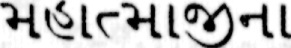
મહાત્માજીના
